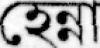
হেন্না
